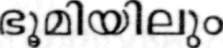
ഭൂമിയിലും
